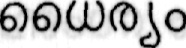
ധൈര്യം
